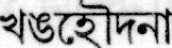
খঙহৌদনা
